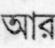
আর
